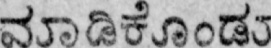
ಮಾಡಿಕೊಂಡು
